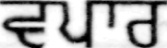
ਵਪਾਰ
